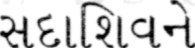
સદાશિવને
